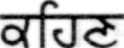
ਕਹਿਣ
